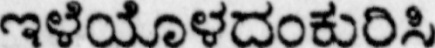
ಇಳೆಯೊಳದಂಕುರಿಸಿ
